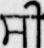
ਸੀ
